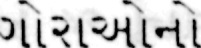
ગોરાઓનો
